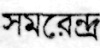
সমরেন্দ্র
